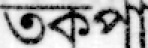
তকপা
